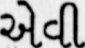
એવી
